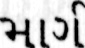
માર્ગ
